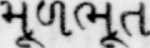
મૂળભૂત
